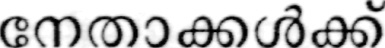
നേതാക്കള്‍ക്ക്
